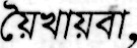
য়ৈখায়বা,
